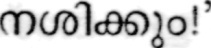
നശിക്കും!’
